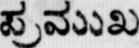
ಪ್ರಮುಖ
